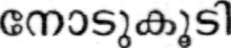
നോടുകൂടി
